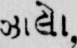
ઝાલો,
